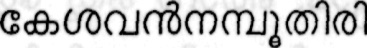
കേശവന്‍നമ്പൂതിരി
